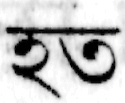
হত
